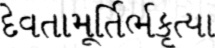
દેવતામૂર્તિર્ભકૃત્યા
